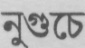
নুগুচে
